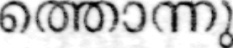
ത്തൊന്നു
